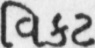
વિકટ
